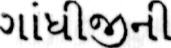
ગાંધીજીની
